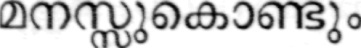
മനസ്സുകൊണ്ടും
